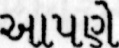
આપણે
